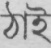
ঠাই
